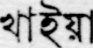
খাইয়া
